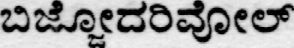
ಬಿಜ್ಜೋದರಿವೋಲ್
